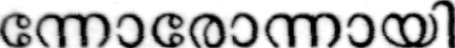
ന്നോരോന്നായി
